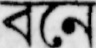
বনে
